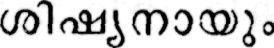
ശിഷ്യനായും
